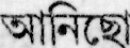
আনিছো
